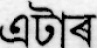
এটাৰ
